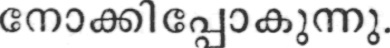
നോക്കിപ്പോകുന്നു.
